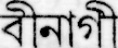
বীনাগী
